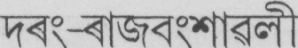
দৰং-ৰাজবংশাৱলী
